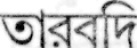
তারবদি
